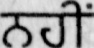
ਨਹੀਂ
